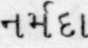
નર્મદા
